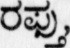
ರಫ್ತು,
